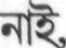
নাই,
